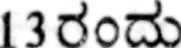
13ರಂದು
